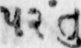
પરંતુ
